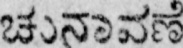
ಚುನಾವಣೆ
